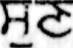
ਸੁਣ
